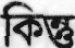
কিন্তু
